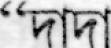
"দাদা
